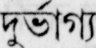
দুর্ভাগ্য
